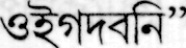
ওইগদবনি”
